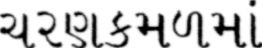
ચરણકમળમાં
